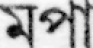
মপা
